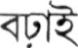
বঢ়াই
